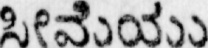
ಸೀಮೆಯು
